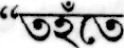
"তহঁতে
